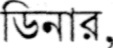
ডিনার,
